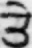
ਤੇ
